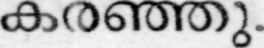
കരഞ്ഞു.
